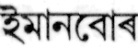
ইমানবোৰ
